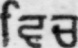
ਵਿਚ
